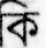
কি
